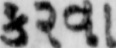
કરવા
